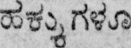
ಹಕ್ಕುಗಳೂ
